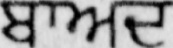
ਬਾਅਦ
